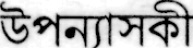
উপন্যাসকী
